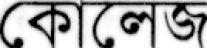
কোলেজ
